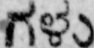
ಗಳು
